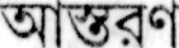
আস্তরণ
